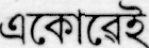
একোৱেই
